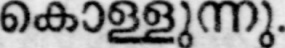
കൊള്ളുന്നു.
